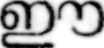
ഈ
